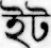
ইট
